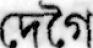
দেগৈ
